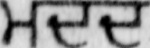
ਮਦਦ
